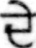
ਦੇ
